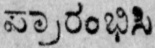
ಪ್ರಾರಂಭಿಸಿ
